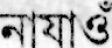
নাযাওঁ
